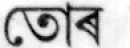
তোৰ
